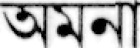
অমনা
